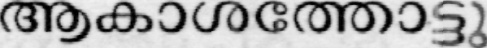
ആകാശത്തോട്ടു
